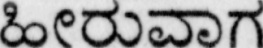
ಹೀರುವಾಗ
